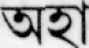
অহা
